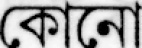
কোনো
